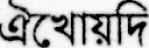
ঐখোয়দি
